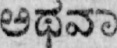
ಅಥವಾ
